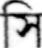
সি
